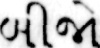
બીજો
